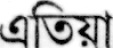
এতিয়া
